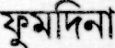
ফুমদিনা
